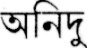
অনিদু
